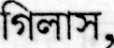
গিলাস,
